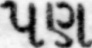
પણ
